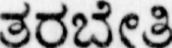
ತರಬೇತಿ
